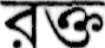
রক্ত
